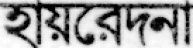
হায়রেদনা
